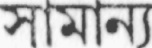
সামান্য
